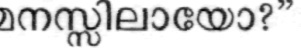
മനസ്സിലായോ?”
